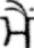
ਮੈਂ
